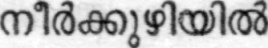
നീര്‍ക്കുഴിയില്‍
